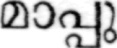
മാപ്പു
